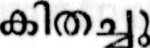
കിതച്ചു
